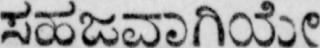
ಸಹಜವಾಗಿಯೇ
